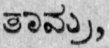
ತಾಮ್ರ,
